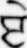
ਏ
